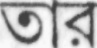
তার
